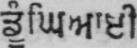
ਡੂੰਘਿਆਈ
